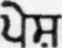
ਪੇਸ਼
